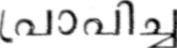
പ്രാപിച്ച
